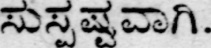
ಸುಸ್ಪಷ್ಟವಾಗಿ.
